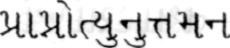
પ્રાપ્રોત્યુનુત્તમ
